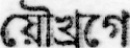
য়ৌখ্রগে
